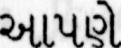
આપણે
